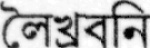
লৈখ্রবনি
